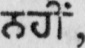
ਨਹੀਂ,
